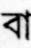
বা
